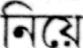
নিয়ে
